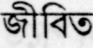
জীবিত
